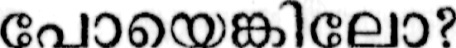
പോയെങ്കിലോ?
